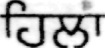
ਹਿਲਾ
